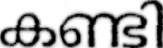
കണ്ടി
